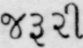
જરૂરી
